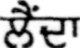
ਲੈਂਦਾ
